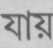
যায়
